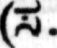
(ಸ.
